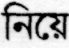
নিয়ে
